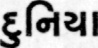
દુનિયા
